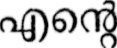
എന്റെ
